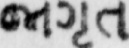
જાગૃત
